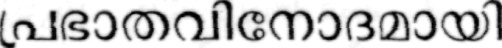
പ്രഭാതവിനോദമായി
